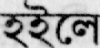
হইলে
